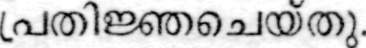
പ്രതിജ്ഞചെയ്തു.
